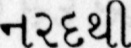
નરદથી
